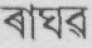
ৰাঘৱ
